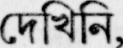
দেখিনি,
